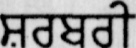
ਸ਼ਰਬਰੀ
